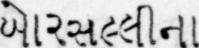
બોરસલ્લીના
